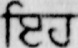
ਇਹ
